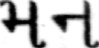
મન
